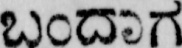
ಬಂದಾಗ
